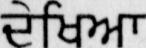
ਦੇਖਿਆ
